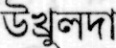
উখ্রুলদা
